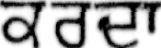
ਕਰਦਾ
